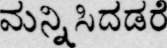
ಮನ್ನಿಸಿದಡರೆ
